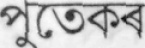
পুতেকৰ
